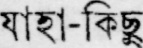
যাহা-কিছু
